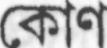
কোণ
